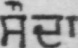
ਸੌਦਾ
